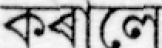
কৰালে
